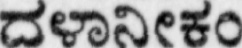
ದಳಾನೀಕಂ
